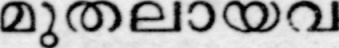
മുതലായവ
